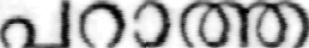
പറാത്ത
